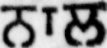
ਨਾਲ
